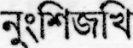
নুংশিজখি
